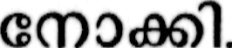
നോക്കി.
